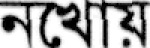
নখোয়
